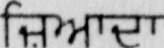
ਜ਼ਿਆਦਾ
